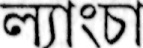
ল্যাংচা
